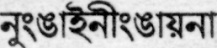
নুংঙাইনীংঙায়না
